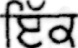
ਇੱਕ
